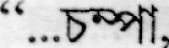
"...চম্পা,
